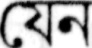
যেন
